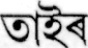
তাইৰ
